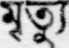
মৃত্যু
